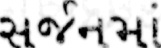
સર્જનમાં
